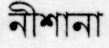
নীশানা
